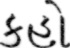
કહો
